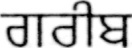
ਗਰੀਬ
